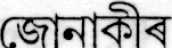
জোনাকীৰ
